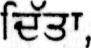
ਦਿੱਤਾ,
